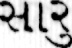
સારુ
